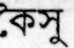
কৈসু
